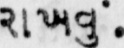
રાખવું.
